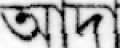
আদা
